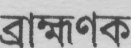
ব্ৰাহ্মণক
